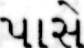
પાસે
